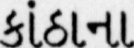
કાંઠાના
